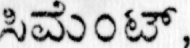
ಸಿಮೆಂಟ್,
